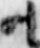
ન
